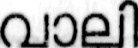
വാലി
